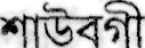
শাউবগী
